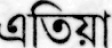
এতিয়া
